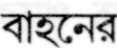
বাহনের
